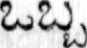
ಒಬ್ಬ
